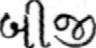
બીજી
